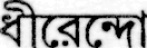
ধীরেন্দো
